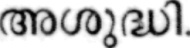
അശുദ്ധി.
